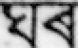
ঘৰ
